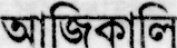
আজিকালি
